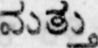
ಮತ್ತು
